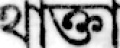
থাক্তা
